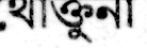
থোক্তুনা
